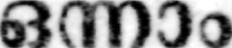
ഒന്നാം
